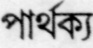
পার্থক্য
